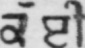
ਕੋਈ
